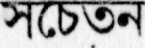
সচেতন
